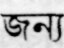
জন্য
